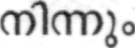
നിന്നും
